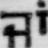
ਜਾਂ
